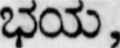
ಭಯ,
